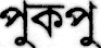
পুকপু
